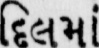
દિલમાં
